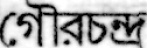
গৌরচন্দ্র
